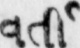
વર્તી
